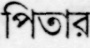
পিতার
